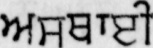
ਅਸਥਾਈ
